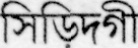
সিড়িদগী
